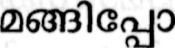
മങ്ങിപ്പോ
